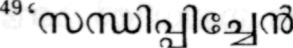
49'സന്ധിപ്പിച്ചേന്‍
